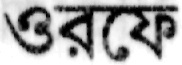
ওরফে
